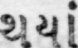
થયાં
